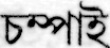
চম্পাই
